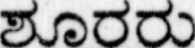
ಶೂರರು
